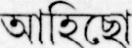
আহিছো
